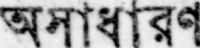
অসাধারণ
